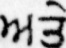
ਅਤੇ
